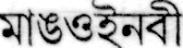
মাঙওইনবী
